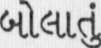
બોલાતું
